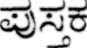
ಪುಸ್ತಕ
